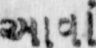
આવાં
